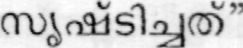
സൃഷ്ടിച്ചത്”
